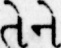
તેને
